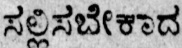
ಸಲ್ಲಿಸಬೇಕಾದ
